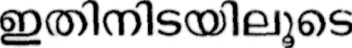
ഇതിനിടയിലൂടെ
